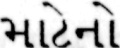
માટેનો
